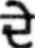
ਦੇ
